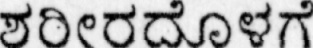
ಶರೀರದೊಳಗೆ
